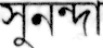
সুনন্দা
